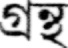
গ্রন্থ
